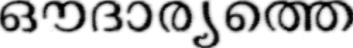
ഔദാര്യത്തെ
